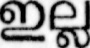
ഇല്ല
